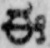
ಈ
